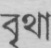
বৃথা
